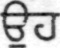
ਉਹ
